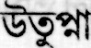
উতুপ্না
